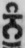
ਨੂੰ
